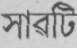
সাৱটি
